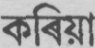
কৰিয়া
